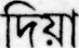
দিয়া
